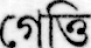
গেত্তি
